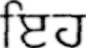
ਇਹ
